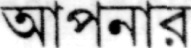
আপনার
